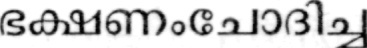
ഭക്ഷണംചോദിച്ച
